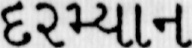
દરમ્યાન
